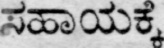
ಸಹಾಯಕ್ಕೆ
